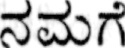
ನಮಗೆ
